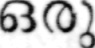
ഒരു
